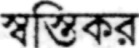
স্বস্তিকর
